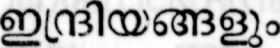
ഇന്ദ്രിയങ്ങളും
